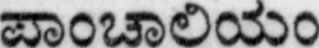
ಪಾಂಚಾಲಿಯಂ
